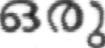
ഒരു
